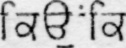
ਕਿਉਂਕਿ
